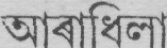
আৰাধিলা
